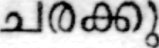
ചരക്കു
